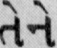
તેને
